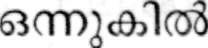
ഒന്നുകില്‍
